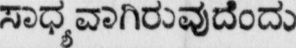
ಸಾಧ್ಯವಾಗಿರುವುದೆಂದು
